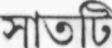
সাতটি
